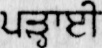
ਪੜ੍ਹਾਈ
